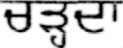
ਚੜ੍ਹਦਾ
